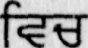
ਵਿਚ
